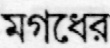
মগধের
